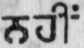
ਨਹੀਂ
